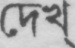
দেখ্
